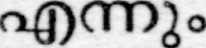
എന്നും
